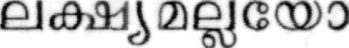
ലക്ഷ്യമല്ലയോ
